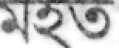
মহত
